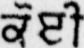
ਕੋਈ
